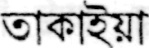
তাকাইয়া
